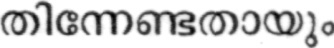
തിന്നേണ്ടതായും
